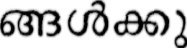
ങ്ങള്‍ക്കു
